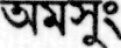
অমসুং
